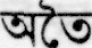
অতৈ
